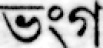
ভংগ
